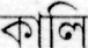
কালি
